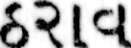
ઠરાવ
